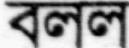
বলল
